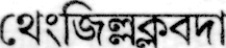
থেংজিল্লক্লবদা
